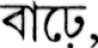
বাঢ়ে,
